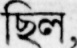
ছিল,
